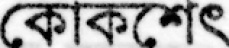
কোকশেৎ
